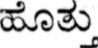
ಹೊತ್ತು
